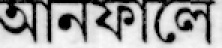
আনফালে
